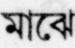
মাঝে
